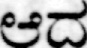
ಆದ
